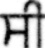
ਸੀ
